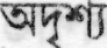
অদৃশ্য
